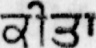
ਕੀਤਾ
